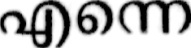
എന്നെ
